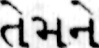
તેમને
